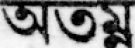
অতম্ন
